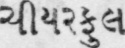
ચીયરફુલ
